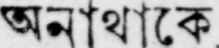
অনাথাকে,
